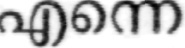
എന്നെ
